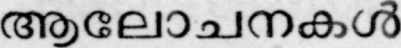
ആലോചനകള്‍
